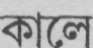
কালে
